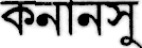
কনানসু
